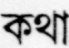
কথা
